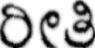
ರೀತಿ
